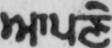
ਆਪਣੇ
